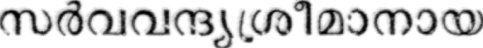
സര്‍വവന്ദ്യശ്രീമാനായ
